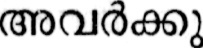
അവര്‍ക്കു
